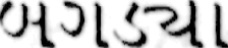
બગડ્યા
